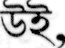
উই,
